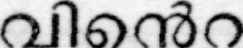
വിന്റെ
